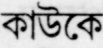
কাউকে
